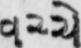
વચ્ચે
